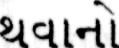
થવાનો
